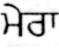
ਮੇਰਾ
